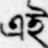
এই
